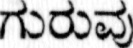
ಗುರುವು
